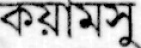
কয়ামসু
